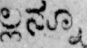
ಲ್ಲನ್ನೂ
